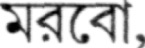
মরবো,
